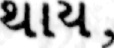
થાય,
